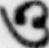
ও
